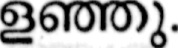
ളഞ്ഞു.
